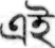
এই
